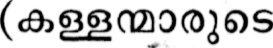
(കള്ളന്മാരുടെ
